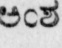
ಅಂಶ
